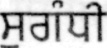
ਸੁਗੰਧੀ
